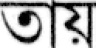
তায়
